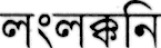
লংলক্কনি
